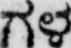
ಗಳ
